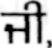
ਜੀ,
